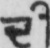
ਦੀ
